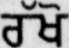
ਰੱਖੋ
